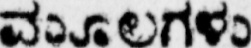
ಮೂಲಗಳು
